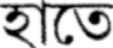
হাতে
